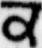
ਕ
